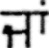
ਜਾਂ
